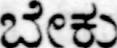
ಬೇಕು
